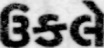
ઉકલે
